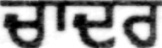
ਚਾਦਰ
